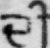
ਦੀ
